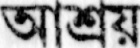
আশ্রয়
